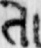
તો
